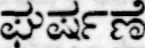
ಘರ್ಷಣೆ
